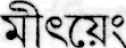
মীৎয়েং
